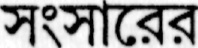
সংসারের
